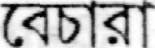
বেচারা
